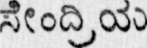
ಸೇಂದ್ರಿಯ
